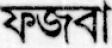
ফজবা
